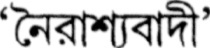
‘নৈরাশ্যবাদী'
